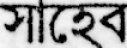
সাহেব
